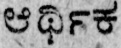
ಆರ್ಥಿಕ
